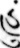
હું
